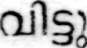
വിട്ടു
